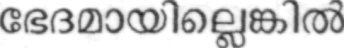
ഭേദമായില്ലെങ്കില്‍
